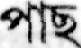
পাছ
